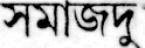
সমাজদু
